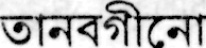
তানবগীনো
